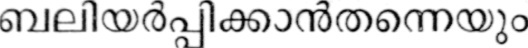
ബലിയര്‍പ്പിക്കാന്‍തന്നെയും
